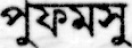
পুফমসু
